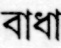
বাধা
